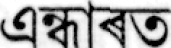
এন্ধাৰত
